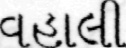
વહાલી
